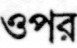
ওপর
